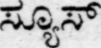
ಸ್ಯೂಸ್
